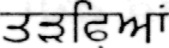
ਤੜਫ਼ਿਆਂ
